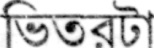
ভিতরটা
